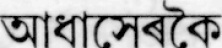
আধাসেৰকৈ
